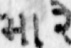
મારે
